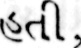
હતી,
